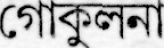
গোকুলনা
